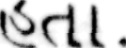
હતા.
